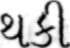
થકી
